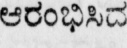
ಆರಂಭಿಸಿದ
